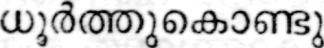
ധൂര്‍ത്തുകൊണ്ടു
